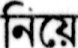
নিয়ে
